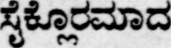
ಸೈಕ್ಲೊರಮಾದ
